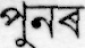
পুনৰ
